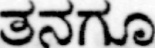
ತನಗೂ
